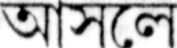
আসলে
